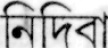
নিদিবা
